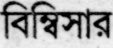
বিম্বিসার
